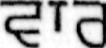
ਵਾਰ
